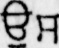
ਉਸ
